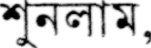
শুনলাম,
